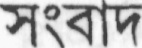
সংবাদ
